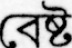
বেষ্ট
